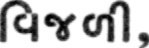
વિજળી,
